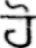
ਹੋ
